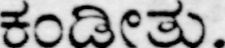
ಕಂಡೀತು.
